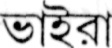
ভাইরা
